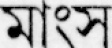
মাংস
